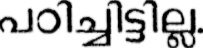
പഠിച്ചിട്ടില്ല.
